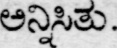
ಅನ್ನಿಸಿತು.
